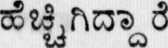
ಹೆಚ್ಚಿಗಿದ್ದಾರೆ
